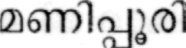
മണിപ്പൂരി
